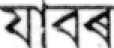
যাবৰ
